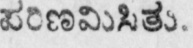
ಪರಿಣಮಿಸಿತು.
